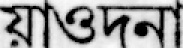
য়াওদনা
